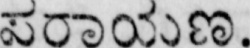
ಪರಾಯಣ.
